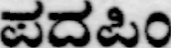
ಪದಪಿ೦
